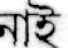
নাই
